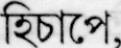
হিচাপে,
